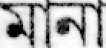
মানা
